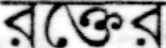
রক্তের
